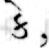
કે,'
